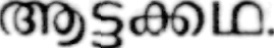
ആട്ടക്കഥ.
